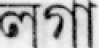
লগা
